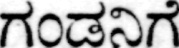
ಗಂಡನಿಗೆ
